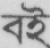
বই
